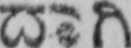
ದಾಗಿ
